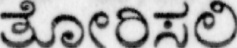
ತೋರಿಸಲಿ
